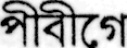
পীবীগে
